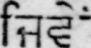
ਜਿਵੇਂ
